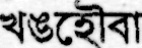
খঙহৌবা
